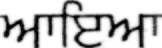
ਆਇਆ
